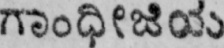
ಗಾಂಧೀಜಿಯ
